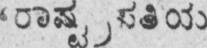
‘ರಾಷ್ಟ್ರಪತಿಯ
